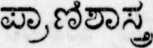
ಪ್ರಾಣಿಶಾಸ್ತ್ರ
